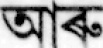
আৰু
